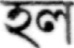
হল
